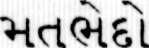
મતભેદો
